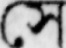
সে
